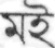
মই
